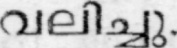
വലിച്ചു.
